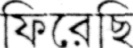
ফিরেছি
